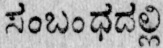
ಸಂಬಂಧದಲ್ಲಿ
